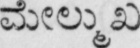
ಮೇಲ್ಮುಖ
